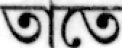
তাতে
